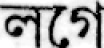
লগে
